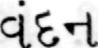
વંદન
